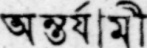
অন্তর্যামী
